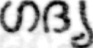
ഗദ്യ
